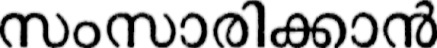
സംസാരിക്കാന്‍
